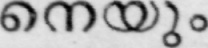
നെയും
